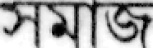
সমাজ
